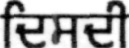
ਦਿਸਦੀ
